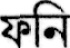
ফনি
